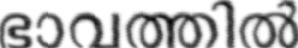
ഭാവത്തില്‍
